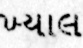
ખ્યાલ
